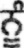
ਨੂੰ
